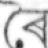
ৰৈ
